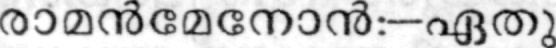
രാമന്‍മേനോന്‍:-ഏതു
